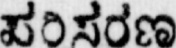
ಪರಿಸರಣ
